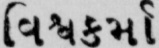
વિશ્વકર્મા
